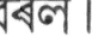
বিৰল
